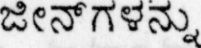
ಜೀನ್ಗಳನ್ನು
